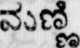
ಮಣ್ಣಿ
